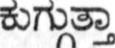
ಕುಗ್ಗುತ್ತಾ
